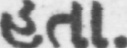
હતા.
